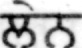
ਲੇਨ
